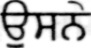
ਉਸਨੇ
